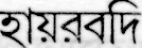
হায়রবদি
